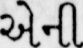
એની
